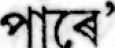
পাৰে'
